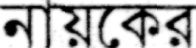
নায়কের
